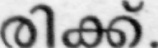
രിക്ക്.
